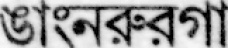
ঙাংনরুরগা
